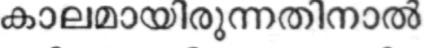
കാലമായിരുന്നതിനാല്‍
